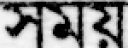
সময়
